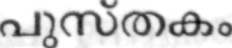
പുസ്തകം
